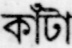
কাঁটা
